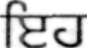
ਇਹ
